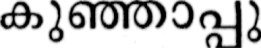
കുഞ്ഞാപ്പു
